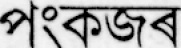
পংকজৰ
